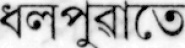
ধলপুৱাতে
